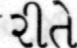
રીતે
